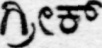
ಗ್ರೀಕ್
